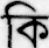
কি
